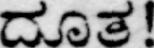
ದೂತ!
